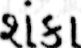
શંકા
